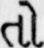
તો
